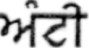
ਅੰਟੀ
